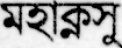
মহাক্নসু
